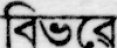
বিভৱে
